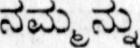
ನಮ್ಮನ್ನು
